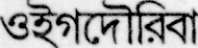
ওইগদৌরিবা
